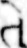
તે
